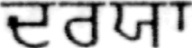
ਦਰਯਾ
